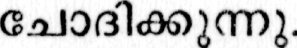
ചോദിക്കുന്നു.
